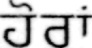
ਹੋਰਾਂ
